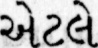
એટલે
